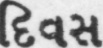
દિવસ
